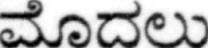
ಮೊದಲು
